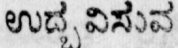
ಉದ್ಭವಿಸುವ
